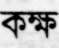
কক্ষ
